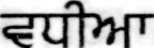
ਵਧੀਆ
